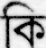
কি
